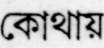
কোথায়
